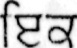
ਇਕ
